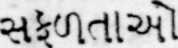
સફળતાઓ
